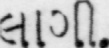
લાગી.
